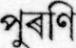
পুৰণি
